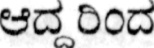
ಆದ್ದರಿಂದ
